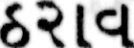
ઠરાવ
